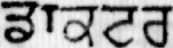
ਡਾਕਟਰ
